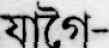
যাগৈ-
